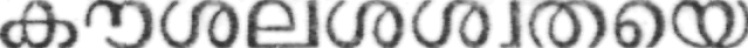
കൗശലശശ്വതയെ
